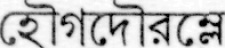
হৌগদৌরম্লে
